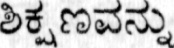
ಶಿಕ್ಷಣವನ್ನು
